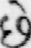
છે
